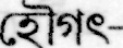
হৌগৎ-
